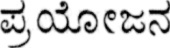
ಪ್ರಯೋಜನ
